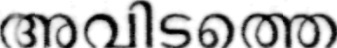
അവിടത്തെ
